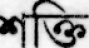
শক্তি
